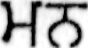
ਮਨ
